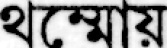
থম্মোয়
